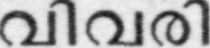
വിവരി
